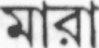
মারা
